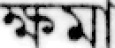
ক্ষমা
